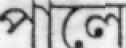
পালে
